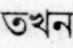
তখন
